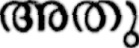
അതു
